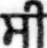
ਸੀ
